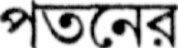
পতনের
